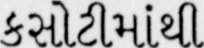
કસોટીમાંથી
